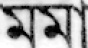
মমা
